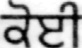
ਕੋਈ
